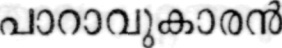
പാറാവുകാരന്‍
